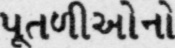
પૂતળીઓનો
